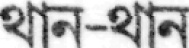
থান-থান
